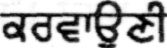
ਕਰਵਾਉਣੀ
